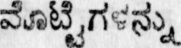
ಮೊಟ್ಟೆಗಳನ್ನು
